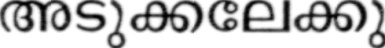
അടുക്കലേക്കു
